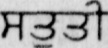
ਸਤੁਤੀ
